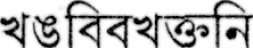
খঙবিবখক্তনি
